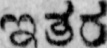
ಇತರ
